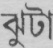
ঝুটা
